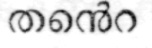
തന്റെ
